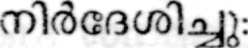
നിര്‍ദ്ദേശിച്ചു:
